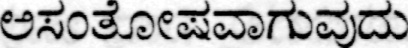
ಅಸಂತೋಷವಾಗುವುದು
